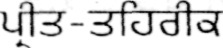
ਪ੍ਰੀਤ-ਤਹਿਰੀਕ
